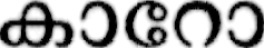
കാറോ
